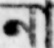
না
